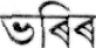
ভৰিৰ
